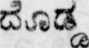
ದೊಡ್ಡ
